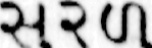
સરળ
